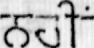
ਨਹੀਂ
